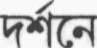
দর্শনে
